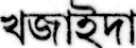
খজাইদা
